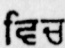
ਵਿਚ
